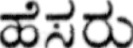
ಹೆಸರು
